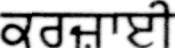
ਕਰਜ਼ਾਈ
